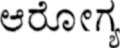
ಆರೋಗ್ಯ
